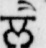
ਲੈ
